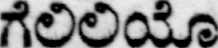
ಗೆಲಿಲಿಯೊ
